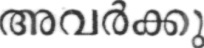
അവര്‍ക്കു
